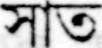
সাত
